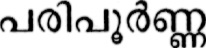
പരിപൂര്‍ണ്ണ
